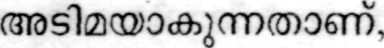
അടിമയാകുന്നതാണ്,
